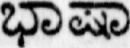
ಭಾಷಾ
